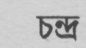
চন্দ্ৰ
